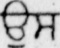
ਉਸ
